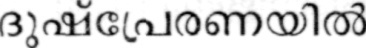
ദുഷ്പ്രേരണയില്‍
